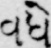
વધે
